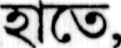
হাতে,
